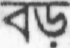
বড়
